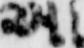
આ
